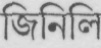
জিনিলি
